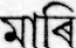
মাৰি
